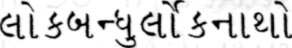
લોકબન્ધુર્લોકનાથો
